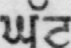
ਘੱਟ
